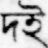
দই
